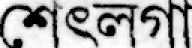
শেৎলগা
